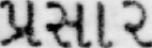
પ્રસાર
